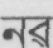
নৱ
